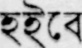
হইবে
